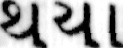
થયા
